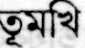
তূমখি
